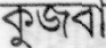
কুজবা
